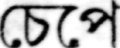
চেপে
